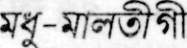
মধু-মালতীগী
